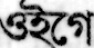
ওইগে
